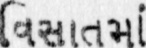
વિસાતમાં
